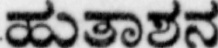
ಹುತಾಶನ
